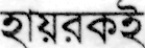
হায়রকই
